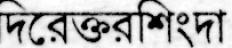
দিরেক্তরশিংদা
